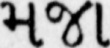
મજા
